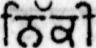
ਨਿੱਕੀ
